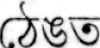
ঠেঙত
